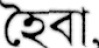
হৈবা,
